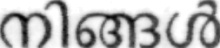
നിങ്ങള്‍
